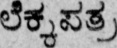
ಲೆಕ್ಕಪತ್ರ
